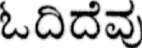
ಓದಿದೆವು
